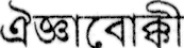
ঐজ্ঞাবোক্কী
